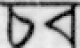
চব
